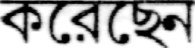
করেছেন
